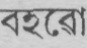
বহৱো
